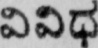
ವಿವಿಧ
